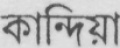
কান্দিয়া
